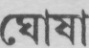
ঘোষা
